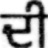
ਦੀ
